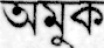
অমুক
